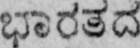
ಭಾರತದ
